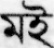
মই
